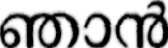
ഞാന്‍
